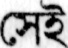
সেই
